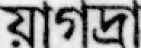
য়াগদ্রা
